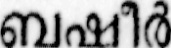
ബഷീര്‍
